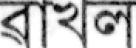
ৱাখল
